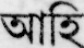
আহি
